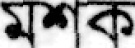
মশক
